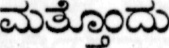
ಮತ್ತೊಂದು
